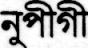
নুপীগী
